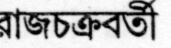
রাজচক্রবর্তী
